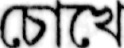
চোখে
